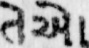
તેઓ
